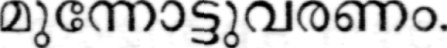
മുന്നോട്ടുവരണം.
